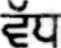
ਵੱਧ
